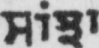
ਸਾਂਝਾ
